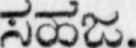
ಸಹಜ.
